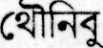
থৌনিবু
